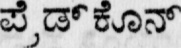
ಪ್ರೆಡ್‌ಕೊನ್
